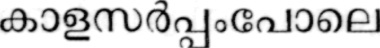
കാളസര്‍പ്പംപോലെ
